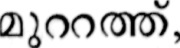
മുററത്ത്,
